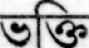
ভক্তি
